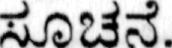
ಸೂಚನೆ.
